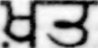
ਖ਼ਤ
